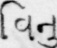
વિનુ
